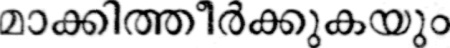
മാക്കിത്തീര്‍ക്കുകയും
